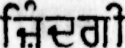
ਜ਼ਿੰਦਗੀ
